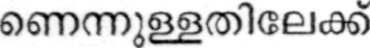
ണെന്നുള്ളതിലേക്ക്
